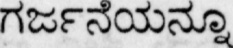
ಗರ್ಜನೆಯನ್ನೂ
